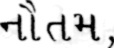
નૌતમ,
